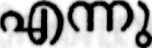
എന്നു
